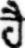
ਹੈ
